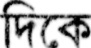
দিকে
